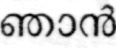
ഞാന്‍
